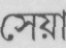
সেয়া
